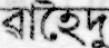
ৱাহৈদু
